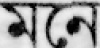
মনে
